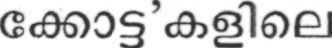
ക്കോട്ട'കളിലെ
